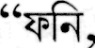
“ফনি,
